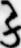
કે
